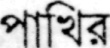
পাখির
